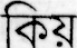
কিয়
